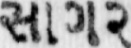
સાગર
